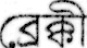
ব্রেক্কী
